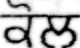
ਕੋਲ
